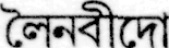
লৈনবীদো
